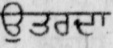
ਉਤਰਦਾ
